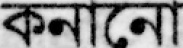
কনানো
